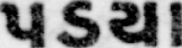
પડયા
